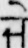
ਜੇ
